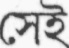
সেই
